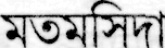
মতমসিদা
